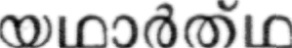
യഥാര്‍ത്ഥ
